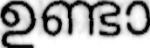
ഉണ്ടാ
